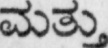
ಮತ್ತು
